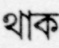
থাক
